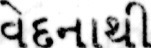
વેદનાથી
